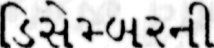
ડિસેમ્બરની
